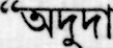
“অদুদা
